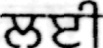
ਲਈ
